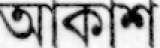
আকাশ
